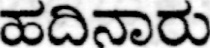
ಹದಿನಾರು
